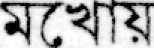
মখোয়
